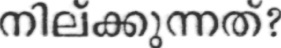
നില്ക്കുന്നത്?
